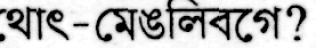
থোৎ-মেঙলিবগে?
